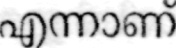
എന്നാണ്
